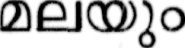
മലയും
